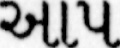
આપ
